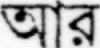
আর
